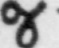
જ
